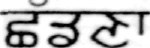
ਛੱਡਣਾ
